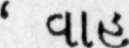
'વાહ
